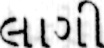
લાગી
